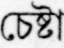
চেষ্টা
